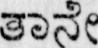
ತಾನೇ
